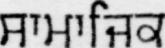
ਸਾਮਾਜਿਕ
